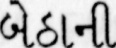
બેઠાની
